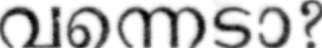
വന്നെടാ?
